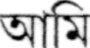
আমি
